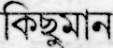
কিছুমান
